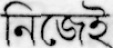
নিজেই
